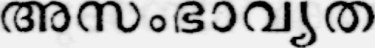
അസംഭാവ്യത
